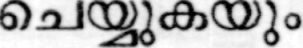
ചെയ്യകയും
